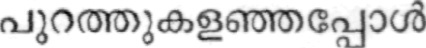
പുറത്തുകളഞ്ഞപ്പോള്‍
